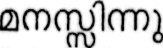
മനസ്സിന്നു
